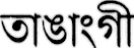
তাঙাংগী
